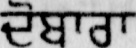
ਦੋਬਾਰਾ
